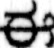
ಈ
